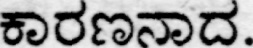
ಕಾರಣನಾದ.
